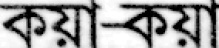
কয়া-কয়া
